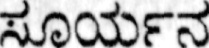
ಸೂರ್ಯನ
